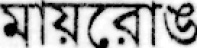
মায়রোঙ
